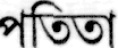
পতিতা
